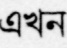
এখন
